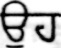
ਉਹ
